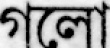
গলো
